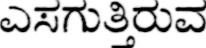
ಎಸಗುತ್ತಿರುವ
